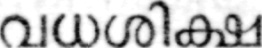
വധശിക്ഷ
